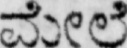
ಮೇಲೆ
